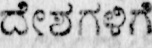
ದೇಶಗಳಿಗೆ
